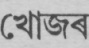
খোজৰ
